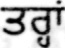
ਤਰ੍ਹਾਂ
